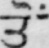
ਤੋਂ
